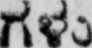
ಗಳು
